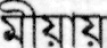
মীয়ায়
